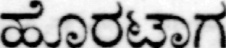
ಹೊರಟಾಗ
